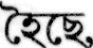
হৈছে,
